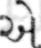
એ
